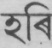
হৰি
